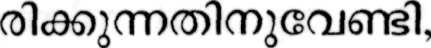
രിക്കുന്നതിനുവേണ്ടി,
